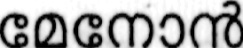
മേനോന്‍
